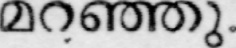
മറഞ്ഞു.
